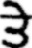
ਤੇ
